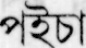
পইচা
